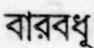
বারবধূ
